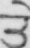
ਤੇ
